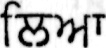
ਲਿਆ
